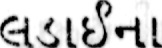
લડાઈના
